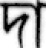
দা
